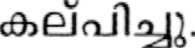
കല്പിച്ചു.
